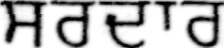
ਸਰਦਾਰ
